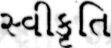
સ્વીકૃતિ
